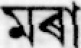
মৰা
